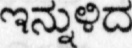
ಇನ್ನುಳಿದ
